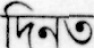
দিনত
